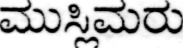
ಮುಸ್ಲಿಮರು
